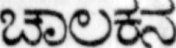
ಚಾಲಕನ
